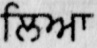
ਲਿਆ
